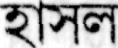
হাসল
